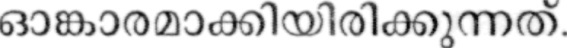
ഓങ്കാരമാക്കിയിരിക്കുന്നത്.
